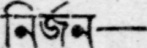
নির্জন—
